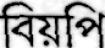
বিয়পি
